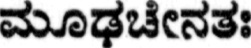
ಮೂಢಚೇನತಃ
